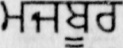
ਮਜਬੂਰ
